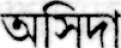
অসিদা
